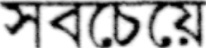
সবচেয়ে
